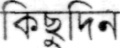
কিছুদিন
